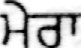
ਮੇਰਾ
